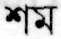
শম
